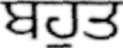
ਬਹੁਤ
